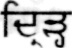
ਦ੍ਰਿੜ੍ਹ
